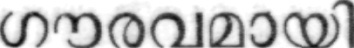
ഗൌരവമായി
